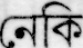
নেকি
